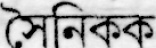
সৈনিকক
